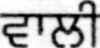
ਵਾਲੀ
